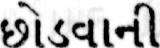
છોડવાની
